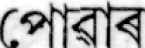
পোৱাৰ
